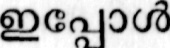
ഇപ്പോള്‍
